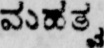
ಮಹತ್ವ
